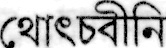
থোৎচবীনি
